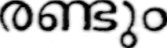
രണ്ടും
